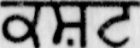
ਕਸ਼ਟ
